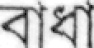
বাধা
